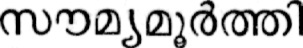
സൌമ്യമൂര്‍ത്തി
